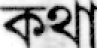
কথা
